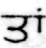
ਤਾਂ
